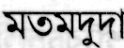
মতমদুদা
